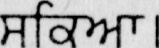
ਸਕਿਆ।
